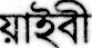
য়াইবী
